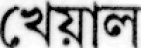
খেয়াল
